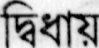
দ্বিধায়
